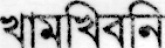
খামখিবনি
